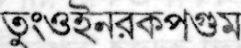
তুংওইনরকপগুম
